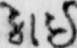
કોઈ
